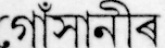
গোঁসানীৰ
